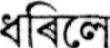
ধৰিলে
